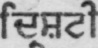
ਦ੍ਰਿਸ਼ਟੀ
